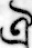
ঐ
